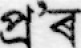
প্র'ৰ
